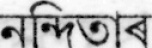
নন্দিতাৰ
